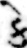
કે
